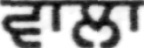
ਵਾਲਾ
